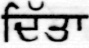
ਦਿੱਤਾ
